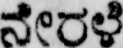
ನೇರಳೆ
